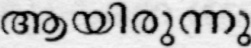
ആയിരുന്നു
